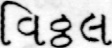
વિઠ્ઠલ
